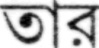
তার
